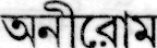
অনীরো
